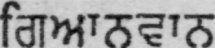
ਗਿਆਨਵਾਨ
